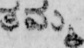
ತಮ್ಮ
